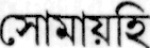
সোমায়হি
